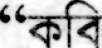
“কবি
